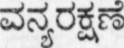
ವನ್ಯರಕ್ಷಣೆ
